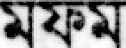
মফম
